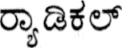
ರ್ಯಾಡಿಕಲ್
